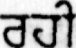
ਰਹੀ
